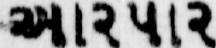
આરપાર
